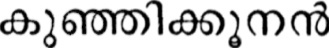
കുഞ്ഞിക്കൂനന്‍
